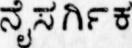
ನೈಸರ್ಗಿಕ
